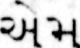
એમ
